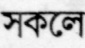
সকলে
